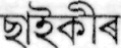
ছাইকীৰ
